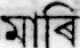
মাৰি
